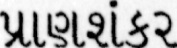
પ્રાણશંકર
